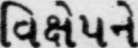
વિક્ષેપને
